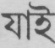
যাই
